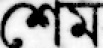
শেম
